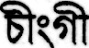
চীংগী
